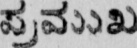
ಪ್ರಮುಖ
